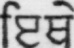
ਇਥੇ
